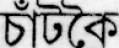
চাঁটকৈ
